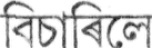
বিচাৰিলে
